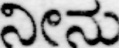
ನೀನು
